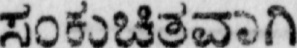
ಸಂಕುಚಿತವಾಗಿ
